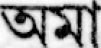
অমা
